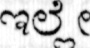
ಇಲ್ಲೇ
